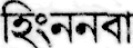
হিংননবা
